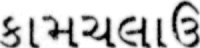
કામચલાઉ
